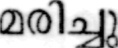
മരിച്ചു
